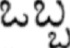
ಒಬ್ಬ
